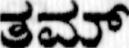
ತಮ್
